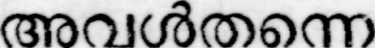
അവള്‍തന്നെ
